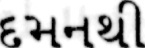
દમનથી
